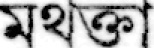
মথক্তা
